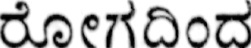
ರೋಗದಿಂದ
